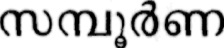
സമ്പൂര്‍ണ
